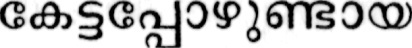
കേട്ടപ്പോഴുണ്ടായ
